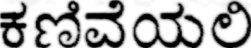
ಕಣಿವೆಯಲಿ
